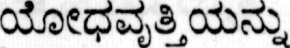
ಯೋಧವೃತ್ತಿಯನ್ನು
